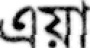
এয়া
